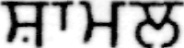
ਸ਼ਾਮਲ
